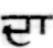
ਦਾ
